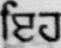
ਇਹ
